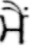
ਮੈਂ
